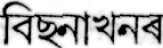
বিছনাখনৰ
